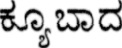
ಕ್ಯೂಬಾದ
